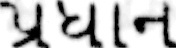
પ્રધાન
